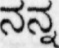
ನನ್ನ
